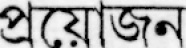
প্রয়োজন
